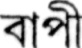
বাপী
